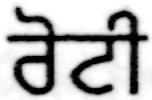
ਰੋਟੀ
